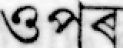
ওপৰ
